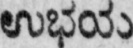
ಉಭಯ
